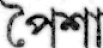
পৈশা
